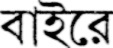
বাইরে
